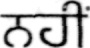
ਨਹੀਂ
